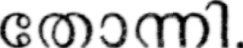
തോന്നി.
